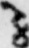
કે
